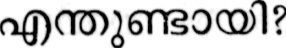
എന്തുണ്ടായി?
